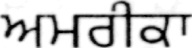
ਅਮਰੀਕਾ
